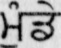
ਮੁੰਡੇ
